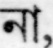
না,
